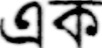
এক
